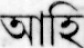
আহি
